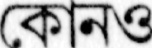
কোনও
